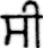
ਸੀ
